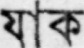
যাক
